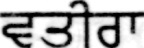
ਵਤੀਰਾ
